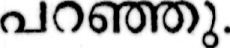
പറഞ്ഞു.
